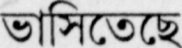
ভাসিতেছে
